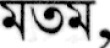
মতম,
